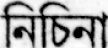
নিচিনা
